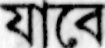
যাবে
